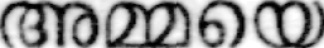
അമ്മയെ
